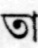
তা
